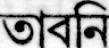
তাবনি
